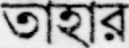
তাহার
